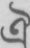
ঐ
